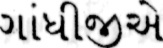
ગાંધીજીએ
